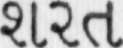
શરત
